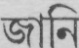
জানি
